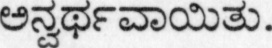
ಅನ್ವರ್ಥವಾಯಿತು.
